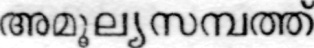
അമൂല്യസമ്പത്ത്
